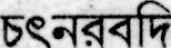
চৎনরবদি
